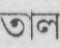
তাল
